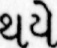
થયે
